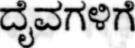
ದೈವಗಳಿಗೆ
